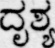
ದೃಶ್ಯ
